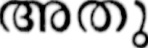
അതു
